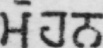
ਮੋਹਨ
